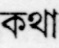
কথা
